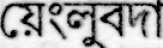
য়েংলুবদা
